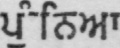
ਪੁੰਨਿਆ
